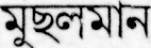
মুছলমান
